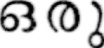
ഒരു
